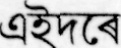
এইদৰে
